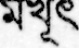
মখূৎ
